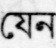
যেন
